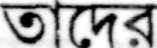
তাদের
